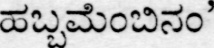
ಹಬ್ಬಮೆಂಬಿನಂ’
